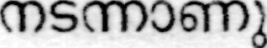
നടന്നാണു
